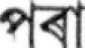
পৰা
